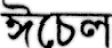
ঈচেল
